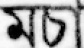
মচা
